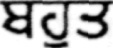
ਬਹੁਤ
